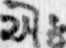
એક
